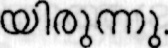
യിരുന്നു.
